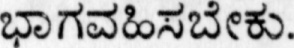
ಭಾಗವಹಿಸಬೇಕು.
